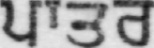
ਪਾਤਰ
